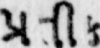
પ્રતીક
